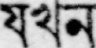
যখন
